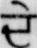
ਦੇ
